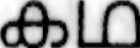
കഥ
